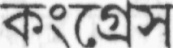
কংগ্রেস
